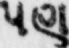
પણ
